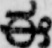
ಈ
